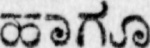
ಹಾಗೂ
